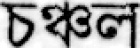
চঞ্চল
